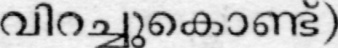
വിറച്ചുകൊണ്ട്)
